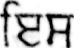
ਇਸ
